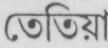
তেতিয়া
